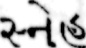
સ્નેહ
